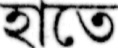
হাতে
